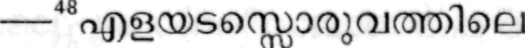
-48എളയടസ്സൊരുവത്തിലെ
